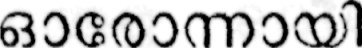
ഓരോന്നായി
